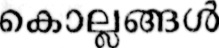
കൊല്ലങ്ങള്‍
